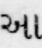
આ
